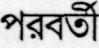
পরবর্তী
